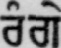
ਰੰਗੇ
